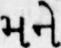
મને
